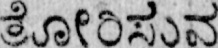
ತೋರಿಸುವ
